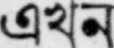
এখন
